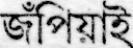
জঁপিয়াই
